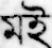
মই
